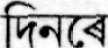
দিনৰে
